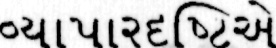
વ્યાપારદષ્ટિએ
